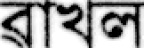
ৱাখল
